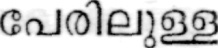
പേരിലുള്ള
